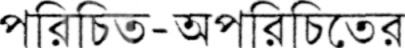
পরিচিত-অপরিচিতের
